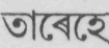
তাৰেহে
